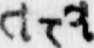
તત્વ
